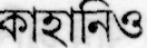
কাহানিও
